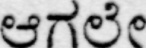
ಆಗಲೇ
